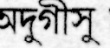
অদুগীসু
